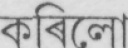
কৰিলো
